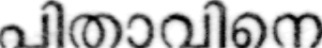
പിതാവിനെ
